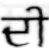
ਦੀ
